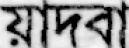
য়াদবা
